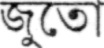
জুতো
